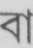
বা
